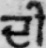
ਦੀ
